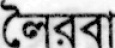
লৈরবা
